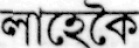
লাহেকৈ
